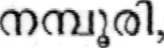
നമ്പൂരി,
